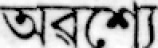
অৱশ্যে
